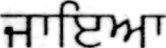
ਜਾਇਆ
